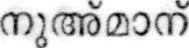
നുഅ്മാന്
